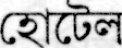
হোটেল
